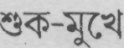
শুক-মুখে
